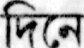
দিনে
